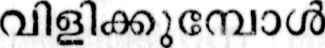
വിളിക്കുമ്പോള്‍
